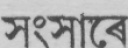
সংসাৰে
